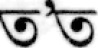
ত'ত
